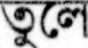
তুলে
